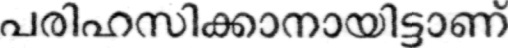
പരിഹസിക്കാനായിട്ടാണ്
